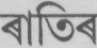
ৰাতিৰ
